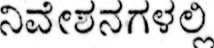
ನಿವೇಶನಗಳಲ್ಲಿ
